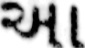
આ
